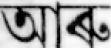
আৰু
